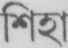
শিহা
